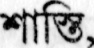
শাস্তি,
